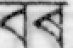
বৰ
